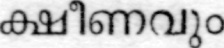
ക്ഷീണവും
